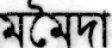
মমৈদা
